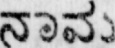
ನಾಮ
